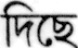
দিছে
